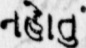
નહોતું
